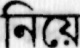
নিয়ে
